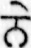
ਨੇ
